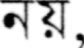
নয়,
